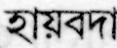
হায়বদা
